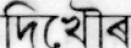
দিখৌৰ
